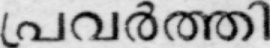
പ്രവര്‍ത്തി
